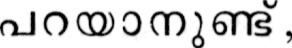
പറയാനുണ്ട്,
